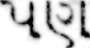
પણ
